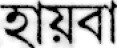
হায়বা
